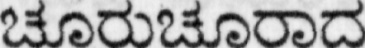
ಚೂರುಚೂರಾದ
